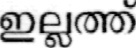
ഇല്ലത്ത്
